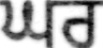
ਘਰ
